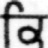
ਕਿ
